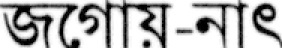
জগোয়-নাৎ
